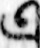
এ
